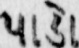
પાડો
